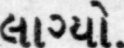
લાગ્યો.
